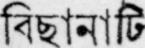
বিছানাটি
